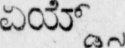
ಏಂii
